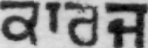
ਕਾਰਜ
